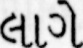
લાગે
